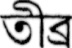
তীব্র
